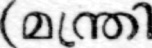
(മന്ത്രി
